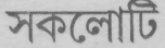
সকলোটি
